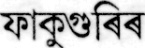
ফাকুগুৰিৰ
